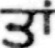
ਤਾਂ
